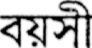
বয়সী
